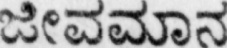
ಜೀವಮಾನ
